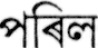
পৰিল
